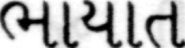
ભાયાત
